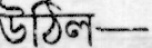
উঠিল-
